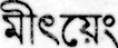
মীৎয়েং
